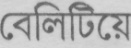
বেলিটিয়ে
